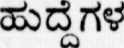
ಹುದ್ದೆಗಳ
